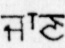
ਜਾਣ
